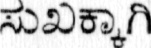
ಸುಖಕ್ಕಾಗಿ
